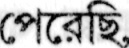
পেরেছি,
